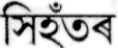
সিহঁতৰ
